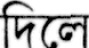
দিলে
